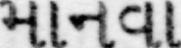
માનવા
